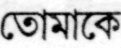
তোমাকে
